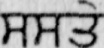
ਸਸਤੇ
